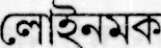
লোইনমক
